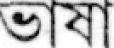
ভাষা
